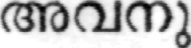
അവനു
